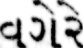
વગેરે
